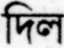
দিল
